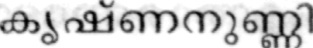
കൃഷ്ണനുണ്ണി
